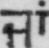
ਜਾਂ
